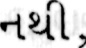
નથી,
